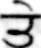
ਤੇ
